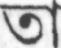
তা
